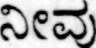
ನೀವು
